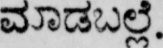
ಮಾಡಬಲ್ಲೆ.
